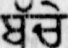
ਬੱਚੇ
